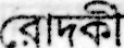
রোদকী
